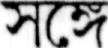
সঙ্গে
